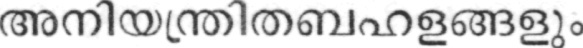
അനിയന്ത്രിതബഹളങ്ങളും
